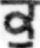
ਕੁ
